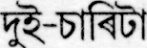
দুই-চাৰিটা
